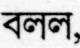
বলল,
